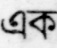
এক
